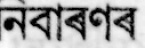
নিবাৰণৰ
